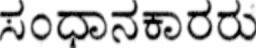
ಸಂಧಾನಕಾರರು
